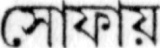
সোফায়
